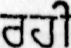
ਰਹੀ
